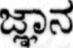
ಜ್ಞಾನ
